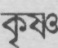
কৃষ্ণ
